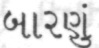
બારણું
